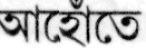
আহোঁতে
